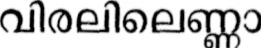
വിരലിലെണ്ണാ
